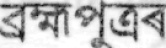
ব্রহ্মপুত্রৰ
